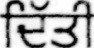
ਦਿੱਤੀ
